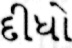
દીધો
